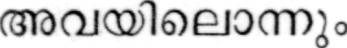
അവയിലൊന്നും
